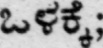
ಒಳಕ್ಕೆ;
